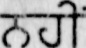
ਨਹੀਂ
